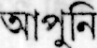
আপুনি
